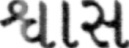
શ્વાસ
